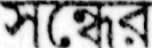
সন্ধের
